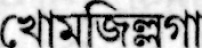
খোমজিল্লগা
